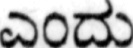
ಎಂದು
